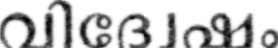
വിദ്വേഷം
